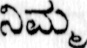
ನಿಮ್ಮ
